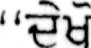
''ਦੇਖੋ
